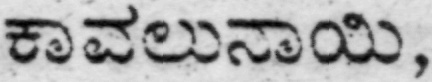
ಕಾವಲುನಾಯಿ,
